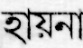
হায়না
